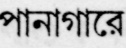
পানাগারে
